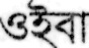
ওইবা
